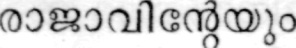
രാജാവിന്റേയും
